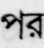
পর
